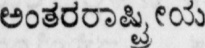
ಅಂತರರಾಷ್ಟ್ರೀಯ
